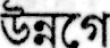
উন্নগে
